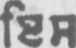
ਇਸ
